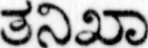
ತನಿಖಾ
